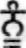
ਨੂੰ
